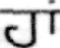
ਹਾਂ
